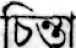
চিন্তা
